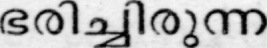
ഭരിച്ചിരുന്ന
